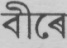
বীৰে
